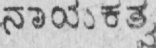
ನಾಯಕತ್ವ
